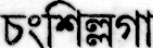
চংশিল্লগা
